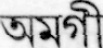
অমগী
